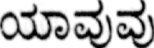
ಯಾವುವು
